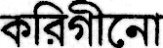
করিগীনো
